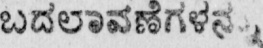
ಬದಲಾವಣೆಗಳನ್ನು
